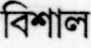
বিশাল
